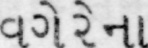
વગેરેના
